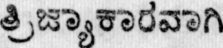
ತ್ರಿಜ್ಯಾಕಾರವಾಗಿ
